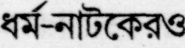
ধর্ম-নাটকেরও
